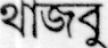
থাজবু
